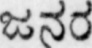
ಜನರ
